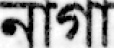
নাগা
